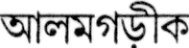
আলমগড়ীক
